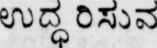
ಉದ್ಧರಿಸುವ
